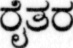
ರೈತರ
